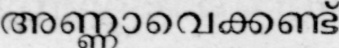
അണ്ണാവെക്കണ്ട്
